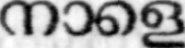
നാളെ
